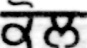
ਕੋਲ
